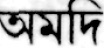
অমদি
